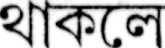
থাকলে
